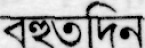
বহুতদিন
